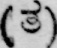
(ತ)
